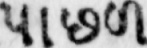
પાછળ
